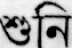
শুনি
